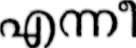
എന്നീ
